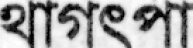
থাগৎপা
